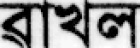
ৱাখল
